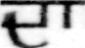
ਦਾ
